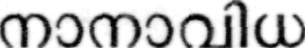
നാനാവിധ
